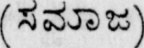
(ಸಮಾಜ)
